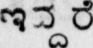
ಇದ್ದರೆ
